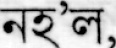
নহ'ল,
